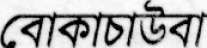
বোকাচাউবা
